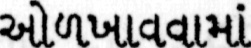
ઓળખાવવામાં
